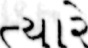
ત્યારે
